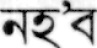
নহ'ব
